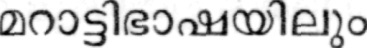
മറാട്ടിഭാഷയിലും
